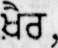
ਖ਼ੈਰ,
